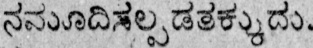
ನಮೂದಿಸಲ್ಪಡತಕ್ಕುದು.
